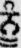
ਨੂੰ
